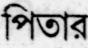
পিতার
